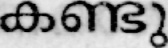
കണ്ടു
